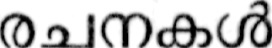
രചനകള്‍
